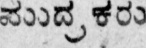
ಮುದ್ರಕರು
